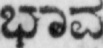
ಭಾವ
